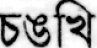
চঙখি
